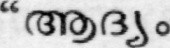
"ആദ്യം
